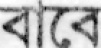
বাবে
